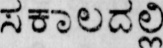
ಸಕಾಲದಲ್ಲಿ
